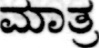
ಮಾತ್ರ
